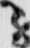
કે
